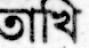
তাখি
